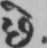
છે.
